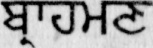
ਬ੍ਰਾਹਮਣ
